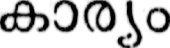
കാര്യം
